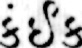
કંઈક
